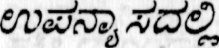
ಉಪನ್ಯಾಸದಲ್ಲಿ
